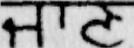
ਜਾਣ
